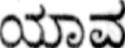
ಯಾವ
